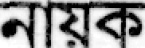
নায়ক
